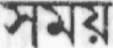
সময়
